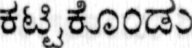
ಕಟ್ಟಿಕೊಂಡು
